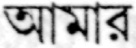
আমার
